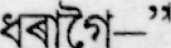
ধৰাগৈ-"
